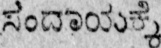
ಸಂದಾಯಕ್ಕೆ
